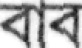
বাব
